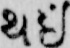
થઈ
